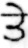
ਤੇ
